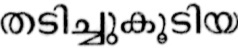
തടിച്ചുകൂടിയ
